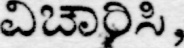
ವಿಚಾರಿಸಿ,
